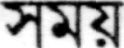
সময়
